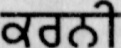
ਕਰਨੀ
